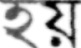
হয়
